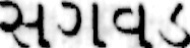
સગવડ
